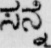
ಸನ್ನೆ
